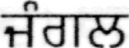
ਜੰਗਲ
